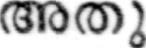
അതു
